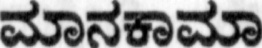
ಮಾನಕಾಮಾ
